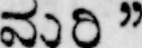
ಮರಿ”
